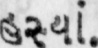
હસ્યાં.
